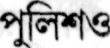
পুলিশও
